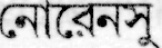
নোরেনসু
